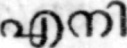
എനി
